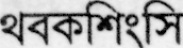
থবকশিংসি
